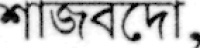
শাজবদো,
